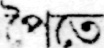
পৈতে
